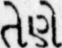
તેણે
